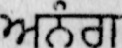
ਅਨੰਗ
